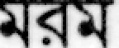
মরম
